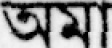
অমা
